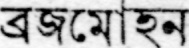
ব্রজমোহন
